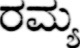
ರಮ್ಯ
